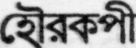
হৌরকপী
